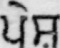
ਪੇਸ਼
